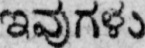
ಇವುಗಳು
